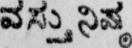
ವಸ್ತುನಿಷ್ಠ
